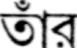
তাঁর
